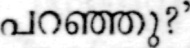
പറഞ്ഞു?’
